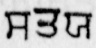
ਸਤਯ
